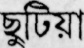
ছুটিয়া
